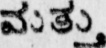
ಮತ್ತು
